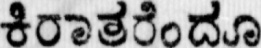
ಕಿರಾತರೆಂದೂ
